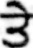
ਤੇ
